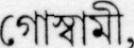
গোস্বামী,
